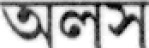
অলস
